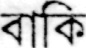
বাকি
